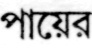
পায়ের
